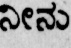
ನೀನು
